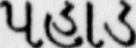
પહાડ
